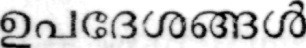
ഉപദേശങ്ങള്‍
